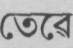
তেৱে
